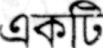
একটি
